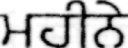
ਮਹੀਨੇ
